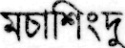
মচাশিংদু
